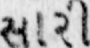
સારી
